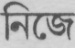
নিজে
